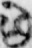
છે
